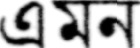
এমন
